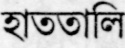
হাততালি
